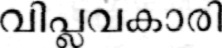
വിപ്ലവകാരി
